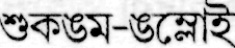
শুকঙম-ঙম্লোই
